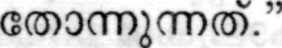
തോന്നുന്നത്.”
